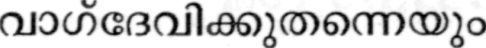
വാഗ്ദേവിക്കുതന്നെയും
